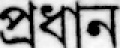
প্রধান
